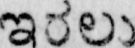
ಇರಲು
